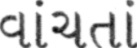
વાંચતાં
